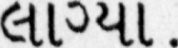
લાગ્યા.
